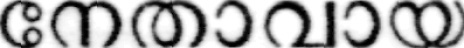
നേതാവായ
